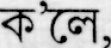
ক'লে,
